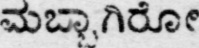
ಮಬ್ಭಾಗಿರೋ
